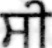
ਸੀ
